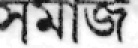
সমাজ
